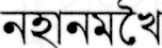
নহানমখৈ
